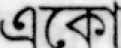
একো
